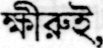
ক্ষীরুই,
